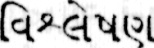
વિશ્લેષણ
